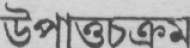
উপাত্তচক্ৰম
